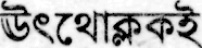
ঊৎথোক্লকই
